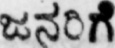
ಜನರಿಗೆ
